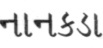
નાનકડા
